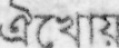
ঐখোয়
